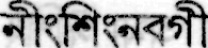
নীংশিংনবগী
